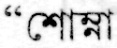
“শোম্না
